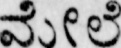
ಮೇಲೆ
